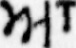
ਆ
